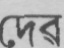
দেৱ
